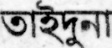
তাইদুনা
